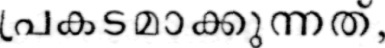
പ്രകടമാക്കുന്നത്,
